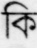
কি
